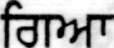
ਗਿਆ
